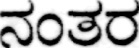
ನಂತರ
